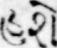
હશે
